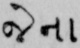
જેના
